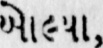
બોલ્યા.
